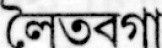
লৈতবগা
